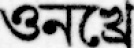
ওনখ্রে
